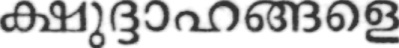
ക്ഷുദ്ദാഹങ്ങളെ
